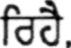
ਰਿਹੈ,
